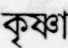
কৃষ্ণা
